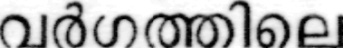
വര്‍ഗത്തിലെ
